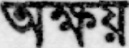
অক্ষয়
